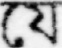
যে
